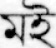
মই
